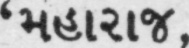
'મહારાજ,
